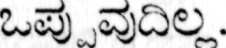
ಒಪ್ಪುವುದಿಲ್ಲ.
